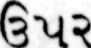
ઉપર
